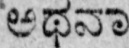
ಅಥವಾ
